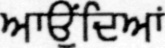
ਆਉਂਦਿਆਂ
